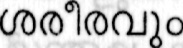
ശരീരവും
